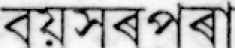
বয়সৰপৰা
